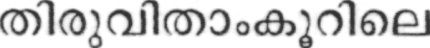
തിരുവിതാംകൂറിലെ
